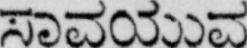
ಸಾವಯುವ
